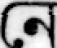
নে
